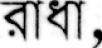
রাধা,
